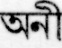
অনী
